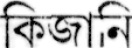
কিজানি
